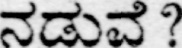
ನಡುವೆ?
